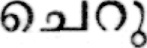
ചെറു
